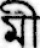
মী
